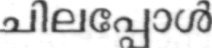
ചിലപ്പോള്‍
